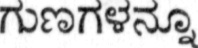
ಗುಣಗಳನ್ನೂ
